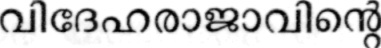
വിദേഹരാജാവിന്റെ
